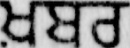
ਖ਼ਬਰ
